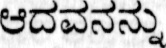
ಆದವನನ್ನು
